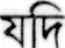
যদি
